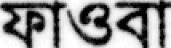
ফাওবা
